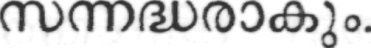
സന്നദ്ധരാകും.
